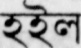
হইল
